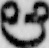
ಆ
